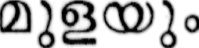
മുളയും
